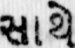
સાથે
